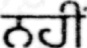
ਨਹੀਂ
